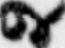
જ
